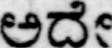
ಅದೇ
